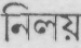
নিলয়
